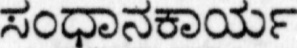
ಸಂಧಾನಕಾರ್ಯ
